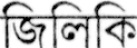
জিলিকি
